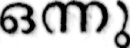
ഒന്നു
